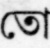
তো
